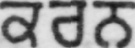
ਕਰਨ
